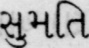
સુમતિ
